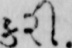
કરી.
